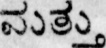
ಮತ್ತು
